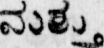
ಮತ್ತು
